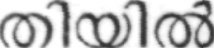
തിയില്‍
